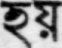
হয়
